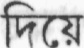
দিয়ে
